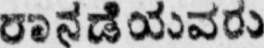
ರಾನಡೆಯವರು
